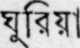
ঘুরিয়া
